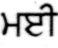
ਮਈ
